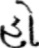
હો
